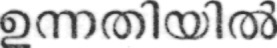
ഉന്നതിയില്‍
